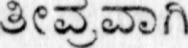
ತೀವ್ರವಾಗಿ
